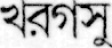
খরগসু
